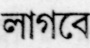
লাগবে
